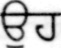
ਉਹ
